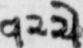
વચ્ચે
